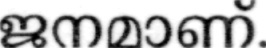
ജനമാണ്.
